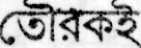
তৌরকই
